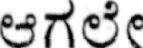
ಆಗಲೇ
